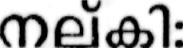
നല്കി:
